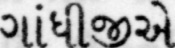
ગાંધીજીએ
